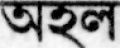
অহল
